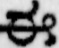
ಈ
